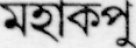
মহাকপু
